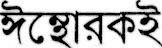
ঈন্থোরকই
